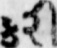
કરી
